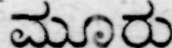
ಮೂರು
